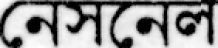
নেসনেল
